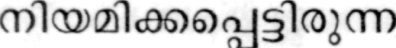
നിയമിക്കപ്പെട്ടിരുന്ന
